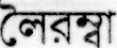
লৈরম্বা
